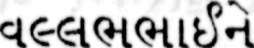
વલ્લભભાઈને
